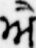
ਐ
